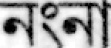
নংনা
